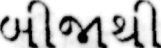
બીજાથી
